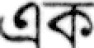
এক
